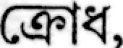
ক্রোধ,
